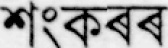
শংকৰৰ
